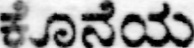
ಕೊನೆಯ
